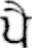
ਪੈ
